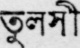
তুলসী
